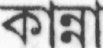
কান্না
